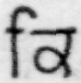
ਕਿ
